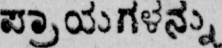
ಪ್ರಾಯಗಳನ್ನು
